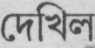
দেখিল
